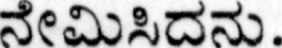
ನೇಮಿಸಿದನು.
